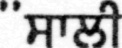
''ਸਾਲੀ
